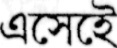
এসেই
